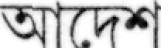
আদেশ
